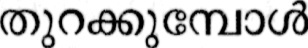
തുറക്കുമ്പോള്‍
